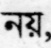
নয়,
